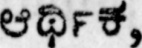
ಆರ್ಥಿಕ
